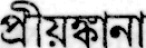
প্রীয়ঙ্কানা
